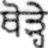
ਥੋੜ੍ਹੇ
